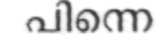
പിന്നെ
